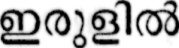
ഇരുളില്‍
